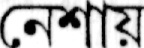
নেশায়
